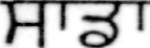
ਸਾਡਾ
